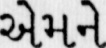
એમને
